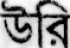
উরি
